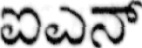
ಐಎನ್
